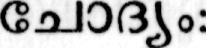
ചോദ്യം:
